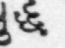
યુદ્ધ
